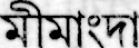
মীমাংদা
